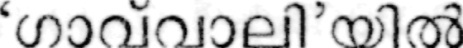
'ഗാവ്‌വാലി'യില്‍
